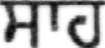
ਸਾਹ
